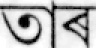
তাৰ
